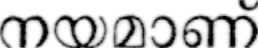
നയമാണ്
